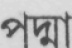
পদ্মা
